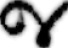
જ
